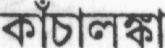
কাঁচালঙ্কা
